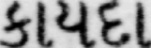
કાયદા
